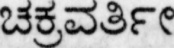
ಚಕ್ರವರ್ತೀ
